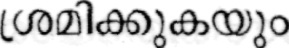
ശ്രമിക്കുകയും
